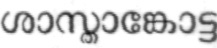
ശാസ്താങ്കോട്ട
